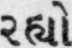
રહ્યો
